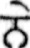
ਨੇ
